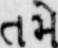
તમે
